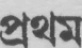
প্ৰথম
